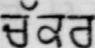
ਚੱਕਰ
